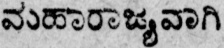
ಮಹಾರಾಜ್ಯವಾಗಿ
